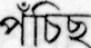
পঁচিছ
